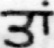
ਤਾਂ
